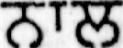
ਨਾਲ
